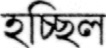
হচ্ছিল
